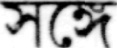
সঙ্গে
